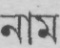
নাম
